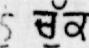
ਚੁੱਕ
